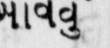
આવવું
